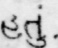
હતું.
